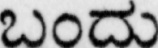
ಬಂದು
